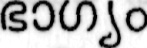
ഭാഗ്യം
